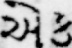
એક
